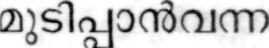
മുടിപ്പാന്‍വന്ന
